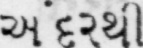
અંદરથી
